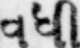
વધી
